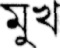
মুখ
